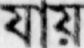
যায়
